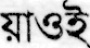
য়াওই
